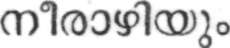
നീരാഴിയും
